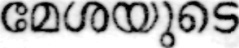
മേശയുടെ
